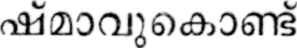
ഷ്മാവുകൊണ്ട്
